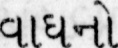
વાઘનો
